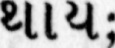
થાય;
